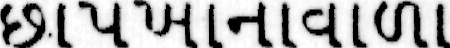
છાપખાનાવાળા
